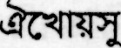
ঐখোয়সু
